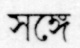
সঙ্গে
